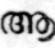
ആ
